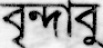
বৃন্দাবু
